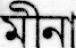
মীনা
